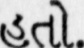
હતો.
